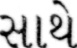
સાથે
